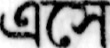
এসে
